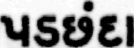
પડછંદા
